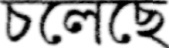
চলেছে
